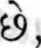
છે,
